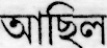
আছিল
